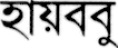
হায়ববু
